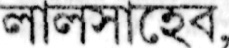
লালসাহেব,
